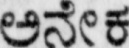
ಅನೇಕ
